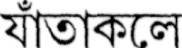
যাঁতাকলে
